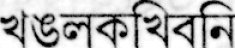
খঙলকখিবনি
